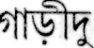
গাড়ীদু
